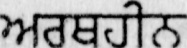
ਅਰਥਹੀਨ
